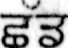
ਛੱਡ
